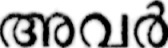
അവര്‍
